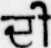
ਦੀ
